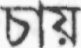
চায়
